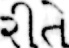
રીતે
